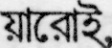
য়ারোই,
